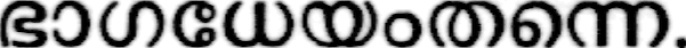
ഭാഗധേയംതന്നെ.
